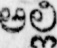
ಅಲ್ಲಿ
